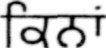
ਕਿਨਾਂ
